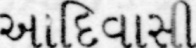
આદિવાસી
